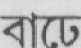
বাঢ়ে
